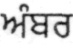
ਅੰਬਰ
